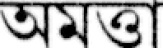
অমত্তা
